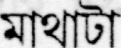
মাথাটা
